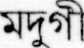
মদুগী
